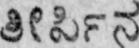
ತೀರ್ಪಿನ
